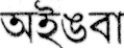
অইঙবা
